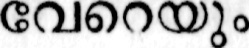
വേറെയും
